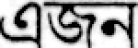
এজন
